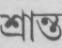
শ্ৰান্ত
